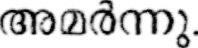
അമര്‍ന്നു.
